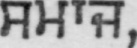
ਸਮਾਜ,
